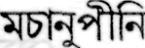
মচানুপীনি
